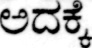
ಅದಕ್ಕೆ
